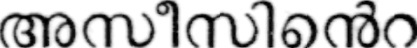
അസീസിന്റെ
